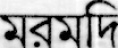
মরমদি
